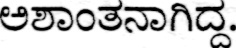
ಅಶಾಂತನಾಗಿದ್ದ.
